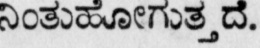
ನಿಂತುಹೋಗುತ್ತದೆ.
